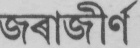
জৰাজীৰ্ণ
